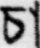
চা
